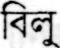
বিলু
